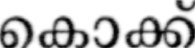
കൊക്ക്
